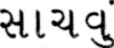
સાચવું
